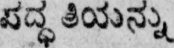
ಪದ್ಧತಿಯನ್ನು
